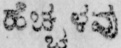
ಹೆಚ್ಚಳವು
